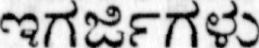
ಇಗರ್ಜಿಗಳು
